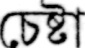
চেষ্টা
